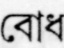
বোধ
